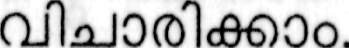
വിചാരിക്കാം.
